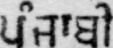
ਪੰਜਾਬੀ
